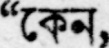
‘‘কেন,
